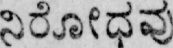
ನಿರೋಧವು
